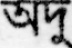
অদু
